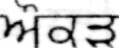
ਔਕੜ
